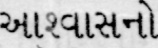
આશ્વાસનો
